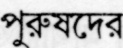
পুরুষদের
